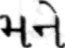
મને
